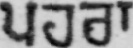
ਪਹਰਾ
